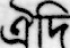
ঐদি
